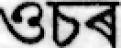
ওচৰ
